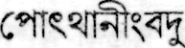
পোৎথানীংবদু
